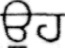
ਉਹ
